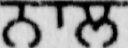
ਨਾਲ
